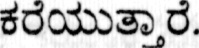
ಕರೆಯುತ್ತಾರೆ.
